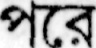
পরে
